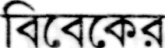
বিবেকের
